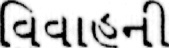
વિવાહની
